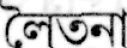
লৈতনা
